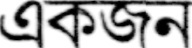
একজন
